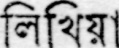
লিখিয়া
